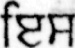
ਇਸ
